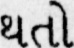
થતો
